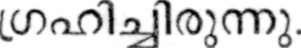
ഗ്രഹിച്ചിരുന്നു.
